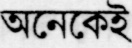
অনেকেই
